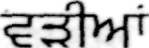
ਵੜੀਆਂ
